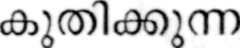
കുതിക്കുന്ന
